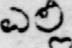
ಎಲ್ಲಿ
